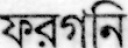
ফরগনি
